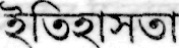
ইতিহাসতা
